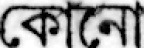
কোনো
